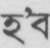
হ'ব
